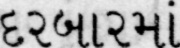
દરબારમાં
